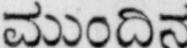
ಮುಂದಿನ
